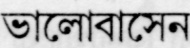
ভালোবাসেন
